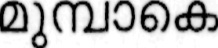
മുമ്പാകെ
